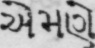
એમણે
